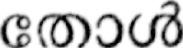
തോള്‍
